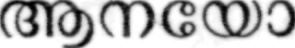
ആനയോ
